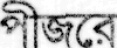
পীজরে
